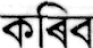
কৰিব
